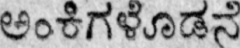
ಅಂಕಿಗಳೊಡನೆ
